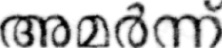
അമര്‍ന്ന്
